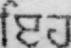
ਇਹ
